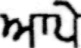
ਆਪੇ
